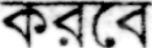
করবে
